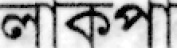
লাকপা
